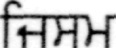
ਜਿਸਮ
